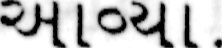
આવ્યા.
